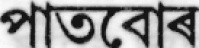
পাতবোৰ
